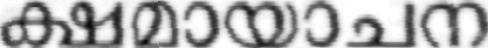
ക്ഷമായാചന
